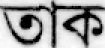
তাক
